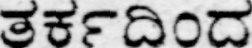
ತರ್ಕದಿಂದ
